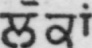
ਲੋਕਾਂ
